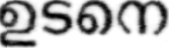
ഉടനെ
